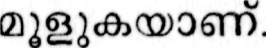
മൂളുകയാണ്.
